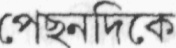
পেছনদিকে
